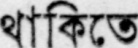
থাকিতে
